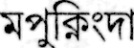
মপুক্নিংদা
